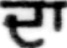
ਦਾ
